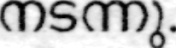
നടന്നു.
